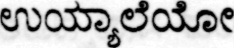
ಉಯ್ಯಾಲೆಯೋ
